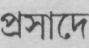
প্ৰসাদে
